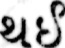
થઈ
